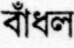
বাঁধল
